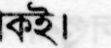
কই
